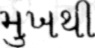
મુખથી
